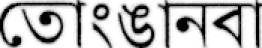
তোংঙানবা
